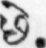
છે.
